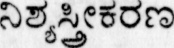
ನಿಶ್ಯಸ್ತ್ರೀಕರಣ
